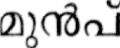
മുന്‍പ്
